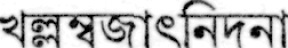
খল্লম্বজাৎনিদনা
